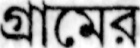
গ্রামের
